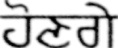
ਹੋਣਗੇ
